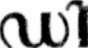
ഡി
